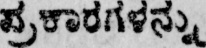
ಪ್ರಕಾರಗಳನ್ನು
